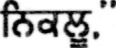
ਨਿਕਲੂ,''
